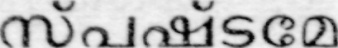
സ്പഷ്ടമേ
